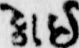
કોઈ
